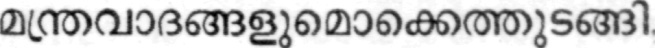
മന്ത്രവാദങ്ങളുമൊക്കെത്തുടങ്ങി.
